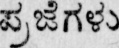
ಪ್ರಜೆಗಳು
